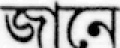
জানে
